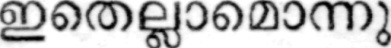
ഇതെല്ലാമൊന്നു
